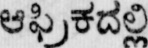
ಆಫ್ರಿಕದಲ್ಲಿ
